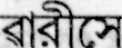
ৱারীসে
